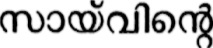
സായ്വിന്റെ
